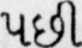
પછી
